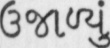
ઉજાળિયું
